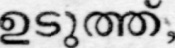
ഉടുത്ത്,
